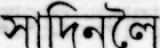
সাদিনলৈ
